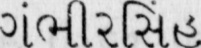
ગંભીરસિંહ
